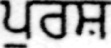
ਪੁਰਸ਼
